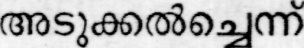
അടുക്കല്‍ച്ചെന്ന്
